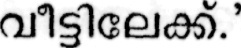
വീട്ടിലേക്ക്.’
